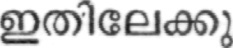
ഇതിലേക്കു
